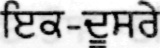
ਇਕ-ਦੂਸਰੇ
